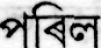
পৰিল
